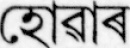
হোৱাৰ
